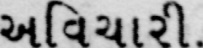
અવિચારી.
